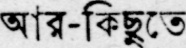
আর-কিছুতে
